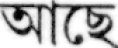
আছে
